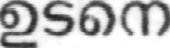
ഉടനെ
